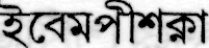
ইবেমপীশক্না
